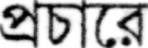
প্রচারে
